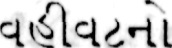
વહીવટનો
